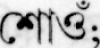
শোওঁ;
